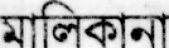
মালিকানা
